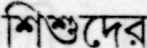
শিশুদের
